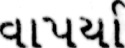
વાપર્યા
